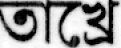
তাখ্রে
